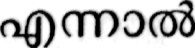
എന്നാല്‍
